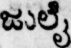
ಜುಲೈ
